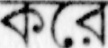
করে
